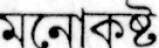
মনোকষ্ট
